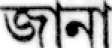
জানা
